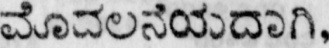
ಮೊದಲನೆಯದಾಗಿ,
